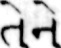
તેને
